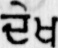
ਦੇਖ
